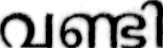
വണ്ടി
